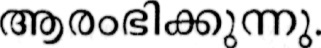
ആരംഭിക്കുന്നു.
